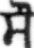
ਸੌ
